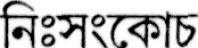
নিঃসংকোচ
